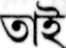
তাই
